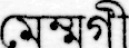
মেম্মগী
